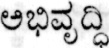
ಅಭಿವೃದ್ಧಿ
